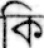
কি
